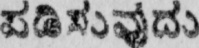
ಪಡಿಸುವುದು
